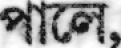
পালে,
